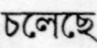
চলেছে
